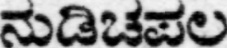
ನುಡಿಚಪಲ
